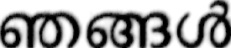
ഞങ്ങള്‍
